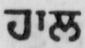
ਹਾਲ
